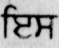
ਇਸ
